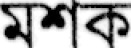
মশক
